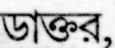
ডাক্তর,
